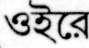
ওইরে
